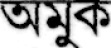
অমুক
